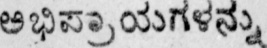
ಅಭಿಪ್ರಾಯಗಳನ್ನು
